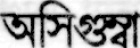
অসিগুম্বা
